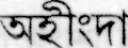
অহীংদা
